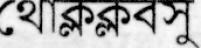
থোক্লক্লবসু
